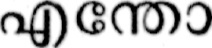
എന്തോ
